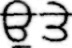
ਉਤੇ
